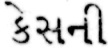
કેસની
